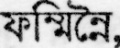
ফম্মিন্নৈ,
